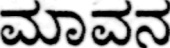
ಮಾವನ
